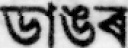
ডাঙৰ
